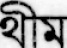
থীম
